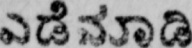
ಎಡೆಮಾಡಿ
